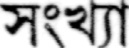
সংখ্যা
